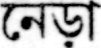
নেড়া
